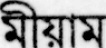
মীয়াম
